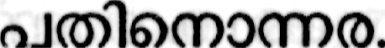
പതിനൊന്നര.
